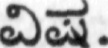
ವಿಷ.
